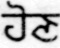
ਹੋਣ
